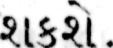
શકશે.
